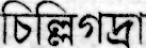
চিল্লিগদ্রা
